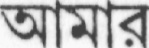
আমার
